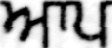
ਆਪ
